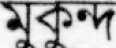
মুকুন্দ
